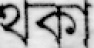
থকা
